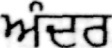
ਅੰਦਰ
